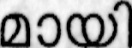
മായി
